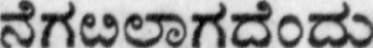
ನೆಗೞಲಾಗದೆಂದು
